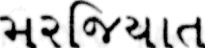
મરજિયાત
